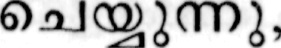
ചെയ്യുന്നു,
